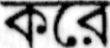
করে
